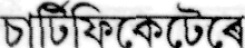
চাৰ্টিফিকেটেৰে
